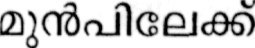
മുന്‍പിലേക്ക്
